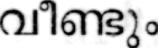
വീണ്ടും
